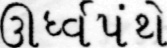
ઊર્ધ્વપંથે
